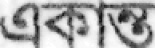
একান্ত
